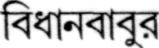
বিধানবাবুর
